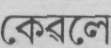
কেৱলে
